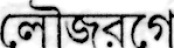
লৌজরগে
